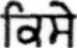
ਕਿਸੇ
